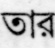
তার
